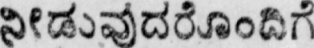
ನೀಡುವುದರೊಂದಿಗೆ
